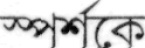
স্পৰ্শকে
